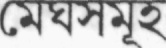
মেঘসমূহ
